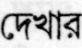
দেখার
